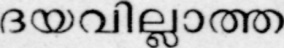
ദയവില്ലാത്ത
